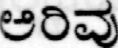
ಅರಿವು
